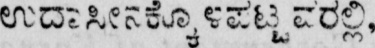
ಉದಾಸೀನಕ್ಕೊಳಪಟ್ಟವರಲ್ಲಿ,
